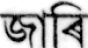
জাৰি
